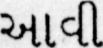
આવી
